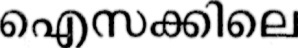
ഐസക്കിലെ
